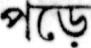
পড়ে
